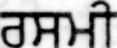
ਰਸਮੀ
